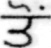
ਤੋਂ
